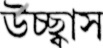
উচ্ছ্বাস
